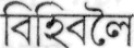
বিহিবলৈ
